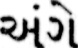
અંગે
